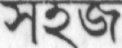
সহজ
